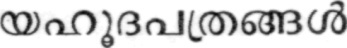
യഹൂദപത്രങ്ങള്‍
